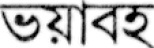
ভয়াবহ
